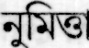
নুমিত্তা
